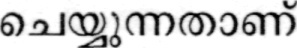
ചെയ്യുന്നതാണ്
